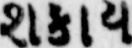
શકાય
